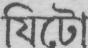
যিটো
